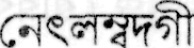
নেৎলম্বদগী
